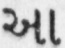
આ
